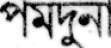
পমদুনা
